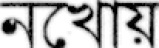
নখোয়
